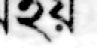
মহয়
